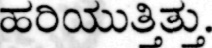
ಹರಿಯುತ್ತಿತ್ತು.
